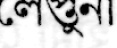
লেপ্তুনা
